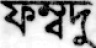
ফম্বদু
